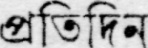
প্রতিদিন
